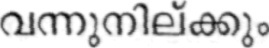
വന്നുനില്ക്കും
